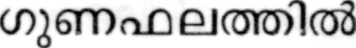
ഗുണഫലത്തില്‍
